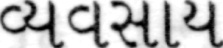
વ્યવસાય
